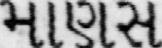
માણસ
